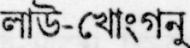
লাউ-খোংগনু
